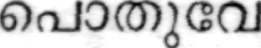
പൊതുവേ
